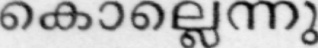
കൊല്ലെന്നു
